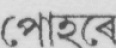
পোহৰে
